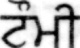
ਟੌਮੀ
